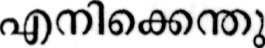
എനിക്കെന്തു
